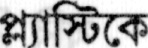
প্ল্যাস্টিকে
